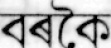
বৰকৈ
